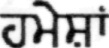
ਹਮੇਸ਼ਾਂ
